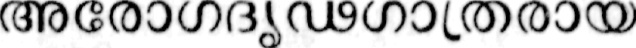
അരോഗദൃഢഗാത്രരായ
